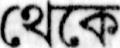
থেকে
